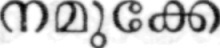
നമുക്കേ
